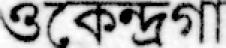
ওকেন্দ্রগা
